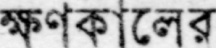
ক্ষণকালের
